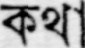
কথা
